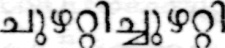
ചുഴറ്റിച്ചുഴറ്റി
